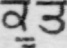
ਕੂਤ
